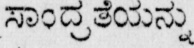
ಸಾಂದ್ರತೆಯನ್ನು
